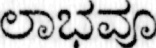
ಲಾಭವೂ
